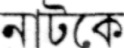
নাটকে
